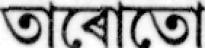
তাৰোতো
